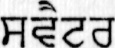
ਸਵੈਟਰ
